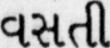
વસતી
